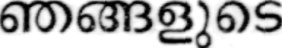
ഞങ്ങളുടെ
